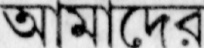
আমাদের
